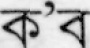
ক'ব
